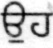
ਉਹ
